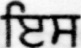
ਇਸ
